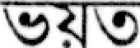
ভয়ত
